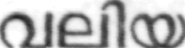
വലിയ
